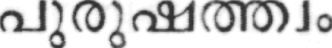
പുരുഷത്ത്വം
